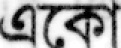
একো
